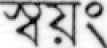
স্বয়ং
